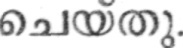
ചെയ്തു.
